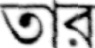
তার
